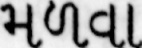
મળવા
